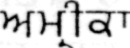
ਅਮ੍ਰੀਕਾ
